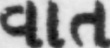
વાત
